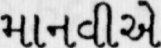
માનવીએ
